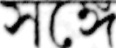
সঙ্গে
